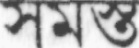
সমস্ত
